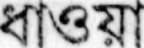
ধাওয়া
